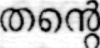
തന്റെ
